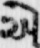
એ
